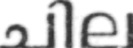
ചില
